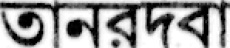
তানরদবা
